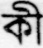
কী
